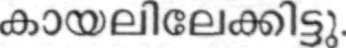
കായലിലേക്കിട്ടു.
